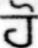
ਹੋ
